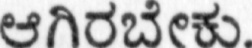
ಆಗಿರಬೇಕು.
